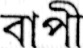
বাপী
